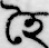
হৈ
